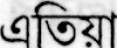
এতিয়া
